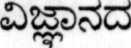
ವಿಜ್ಞಾನದ
